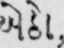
બેઠો,
